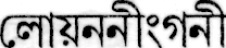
লোয়ননীংগনী
